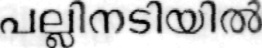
പല്ലിനടിയില്‍
